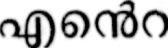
എന്റെ
